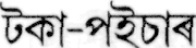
টকা-পইচাৰ
